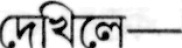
দেখিলে-
